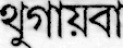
থুগায়বা
